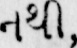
નથી,
